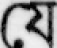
যে
